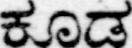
ಕೂಡ
